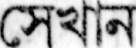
সেখান
